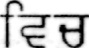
ਵਿਚ
